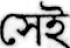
সেই
